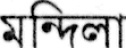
মন্দিলা
